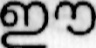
ഈ
